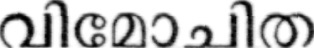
വിമോചിത
